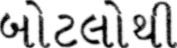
બોટલોથી
